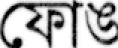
ফোঙ
